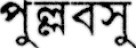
পুল্লবসু
